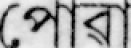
পোৱা
